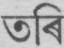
তৰি
